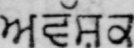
ਅਵੱਸ਼ਕ
